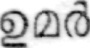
ഉമര്‍
